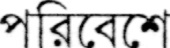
পরিবেশে
